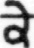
ਕੇ
